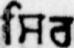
ਸਿਰ
